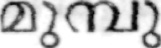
മുമ്പു
